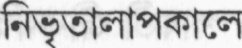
নিভৃতালাপকালে
